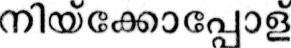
നിയ്ക്കോപ്പോള്
